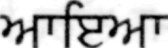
ਆਇਆ
